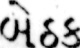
બેઠક
